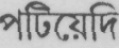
পটিয়েদি
